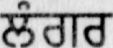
ਲੰਗਰ
